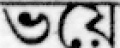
ভয়ে
